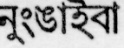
নুংঙাইবা
